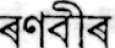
ৰণবীৰ
